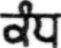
ਕੰਧ
